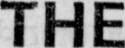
THE
